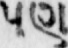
પણ
